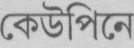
কেউপিনে
